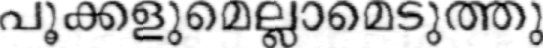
പൂക്കളുമെല്ലാമെടുത്തു
